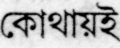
কোথায়ই
